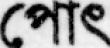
পোৎ
